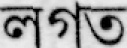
লগত
